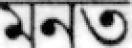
মনত
